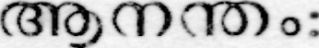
ആനന്തം:
